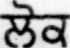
ਲੋਕ
